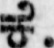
ಕೆ.
